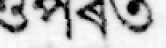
ওপৰত
